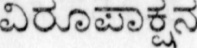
ವಿರೂಪಾಕ್ಷನ
